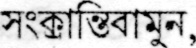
সংক্রান্তিবামুন,
